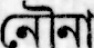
নৌনা
